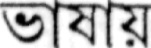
ভাষায়
